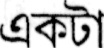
একটা
